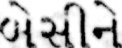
બેસીને
